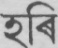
হৰি
